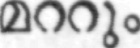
മററും
